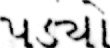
પડ્યો
